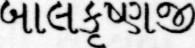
બાલકૃષ્ણજી
